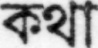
কথা
